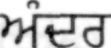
ਅੰਦਰ
